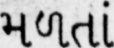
મળતાં
